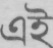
এই
